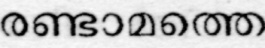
രണ്ടാമത്തെ
